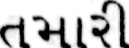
તમારી
